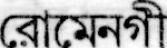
রোমেনগী
